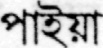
পাইয়া
